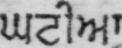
ਘਟੀਆ
